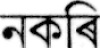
নকৰি
